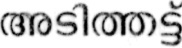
അടിത്തട്ട്
